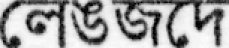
লেঙজদে
